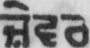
ਜ਼ੇਵਰ
